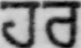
ਹਰ
